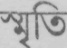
স্মৃতি
